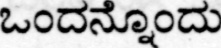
ಒಂದನ್ನೊಂದು
